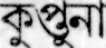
কুপ্তুনা
